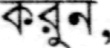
করুন,
